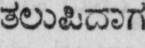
ತಲುಪಿದಾಗ
